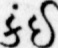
કંઈ
